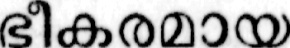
ഭീകരമായ
